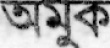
অমুক
